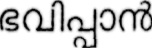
ഭവിപ്പാന്‍
